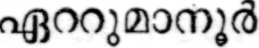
ഏററുമാനൂര്‍
